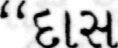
"દાસ
